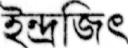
ইন্দ্রজিৎ
